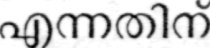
എന്നതിന്
